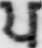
ਪ
